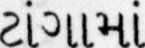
ટાંગામાં
